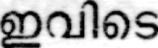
ഇവിടെ
